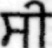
ਸੀ
